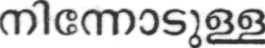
നിന്നോടുള്ള
